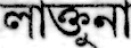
লাক্তুনা
